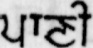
ਪਾਣੀ
